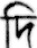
দি
